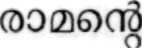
രാമന്റെ
